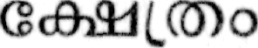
ക്ഷേത്രം
